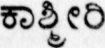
ಕಾಶ್ಮೀರಿ
